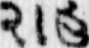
રાહ
